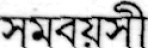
সমবয়সী
